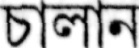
চালান
